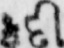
કદી
